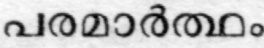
പരമാര്‍ത്ഥം
